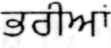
ਭਰੀਆਂ
